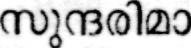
സുന്ദരിമാ
